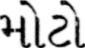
મોટો
